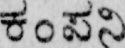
ಕಂಪನಿ
